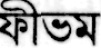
ফীভম
